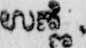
ಉಣ್ಣೆ,
